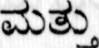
ಮತ್ತು
